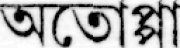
অতোপ্পা
